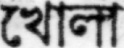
খোলা
